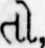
તો,
